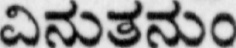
ವಿನುತನುಂ
